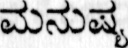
ಮನುಷ್ಯ
